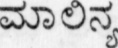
ಮಾಲಿನ್ಯ
